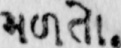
મળતો.
